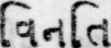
વિનિતિ
